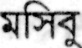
মসিবু
